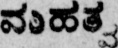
ಮಹತ್ವ
